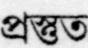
প্রস্তুত
